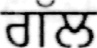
ਗੱਲ
